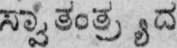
ಸ್ವಾತಂತ್ರ್ಯದ
